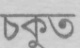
চকুত
